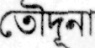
তৌদূনা
